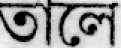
তালে
